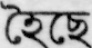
হৈছে
